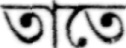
তাতে
